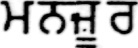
ਮਨਜ਼ੂਰ
